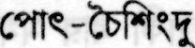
পোৎ-চৈশিংদু
